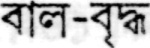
বাল-বৃদ্ধ
